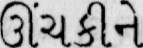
ઊંચકીને
